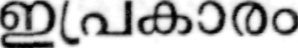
ഇപ്രകാരം
